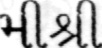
મીશ્રી
